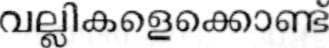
വല്ലികളെക്കൊണ്ട്
